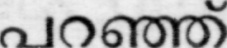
പറഞ്ഞ്
